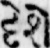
દેશે
